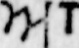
ਆ
